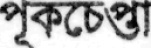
পূকচেপ্তা
